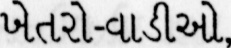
ખેતરો-વાડીઓ,
